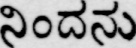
ನಿಂದನು
